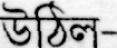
উঠিল-
